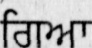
ਗਿਆ
